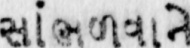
સાંભળવાને
